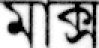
মাক্স
